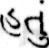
હતું
